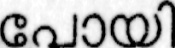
പോയി
